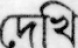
দেখি
